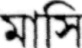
মাসি
